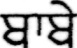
ਬਾਬੇ
